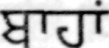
ਬਾਹਾਂ
